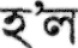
হ'ল
